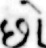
છો
